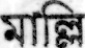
মাল্লি
